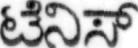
ಟೆನಿಸ್
